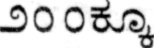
೨೦೦ಕ್ಕೂ
